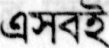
এসবই
